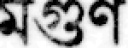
মগুণ
